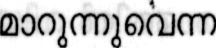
മാറുന്നുവെന്ന
